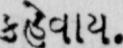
કહેવાય.
